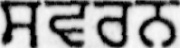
ਸਵਰਨ
